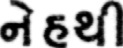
નેહથી
